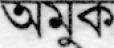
অমুক
